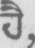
ਹੈ,
